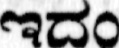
ಇದಂ
